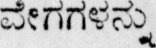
ವೇಗಗಳನ್ನು
